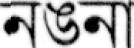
নঙনা
